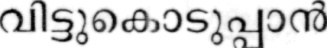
വിട്ടുകൊടുപ്പാന്‍
